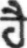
ਹੈ
